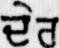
ਦੇਰ
